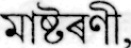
মাষ্টৰণী,
